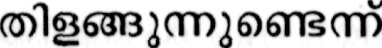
തിളങ്ങുന്നുണ്ടെന്ന്
